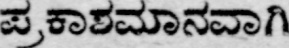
ಪ್ರಕಾಶಮಾನವಾಗಿ
